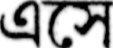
এসে
